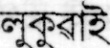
লুকুৱাই
